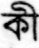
কী
